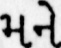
મને
